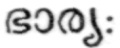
ഭാര്യ:
